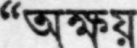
‘‘অক্ষয়
